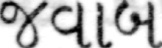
જવાબ
